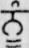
ਨੂੰ
